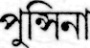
পুন্সিনা
